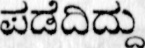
ಪಡೆದಿದ್ದು
